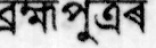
ব্রহ্মপুত্রৰ
